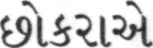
છોકરાએ
